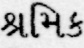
શ્રમિક
